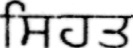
ਸਿਹਤ
